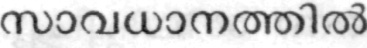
സാവധാനത്തില്‍
